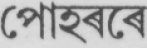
পোহৰৰে
